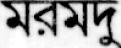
মরমদু
